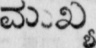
ಮುಖ್ಯ
